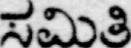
ಸಮಿತಿ
